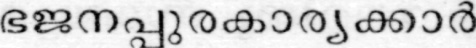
ഭജനപ്പുരകാര്യക്കാര്‍
